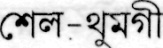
শেল-থুমগী
